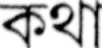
কথা
